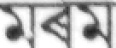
মৰম
